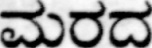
ಮರದ
